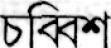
চব্বিশ
